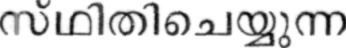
സ്ഥിതിചെയ്യുന്ന
